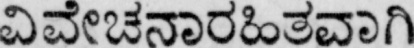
ವಿವೇಚನಾರಹಿತವಾಗಿ
